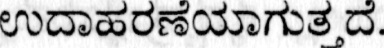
ಉದಾಹರಣೆಯಾಗುತ್ತದೆ.
